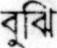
বুঝি
